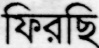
ফিরছি
